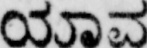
ಯಾವ
